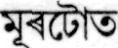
মূৰটোত
